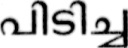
പിടിച്ച
